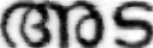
അട
